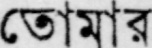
তোমার
